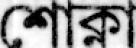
শোক্না
